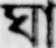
ঘা
